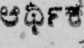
ಆರ್ಥಿಕ
